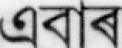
এবাৰ
